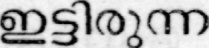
ഇട്ടിരുന്ന
